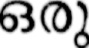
ഒരു
